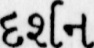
દર્શન
